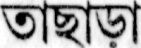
তাছাড়া
